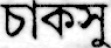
চাকসু
